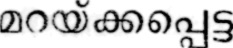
മറയ്ക്കപ്പെട്ട
